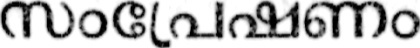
സംപ്രേഷണം
